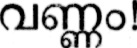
വണ്ണം!
